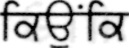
ਕਿਉਂਕਿ
